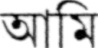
আমি
